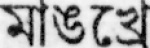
মাঙখ্রে
